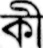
কী
